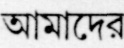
আমাদের
